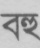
বহু
